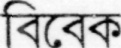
বিবেক
